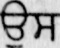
ਉਸ
